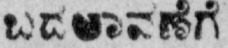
ಬದಲಾವಣೆಗೆ
